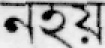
নহয়
